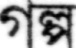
গল্প
